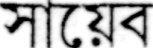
সায়েব
